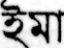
ইমা
